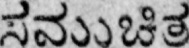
ಸಮುಚಿತ
